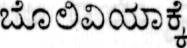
ಬೊಲಿವಿಯಾಕ್ಕೆ
